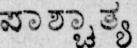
ಪಾಶ್ಚಾತ್ಯ
